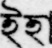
ইহা
